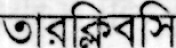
তারক্লিবসি
